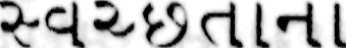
સ્વચ્છતાના
